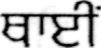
ਥਾਈਂ
